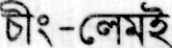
চীং-লেমই
